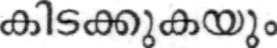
കിടക്കുകയും
